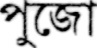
পুজো
